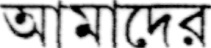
আমাদের
